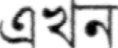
এখন
